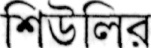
শিউলির
